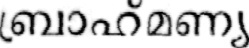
ബ്രാഹ്മണ്യ
